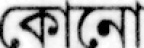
কোনো
